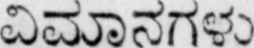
ವಿಮಾನಗಳು
